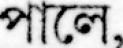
পালে,
